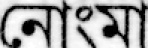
নোংমা
